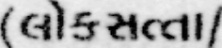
(લોકસત્તા/
